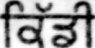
ਕਿੱਡੀ
